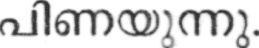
പിണയുന്നു.
